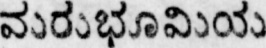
ಮರುಭೂಮಿಯ
